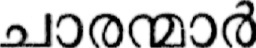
ചാരന്മാര്‍
